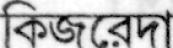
কিজরেদা
